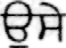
ਉਸੇ
